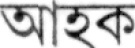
আহক
